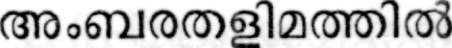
അംബരതളിമത്തില്‍
